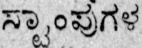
ಸ್ಟಾಂಪುಗಳ
